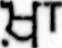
ਖ਼ਾ
